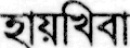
হায়খিবা
